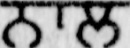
ਨਾਲ
